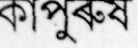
কাপুৰুষ
